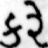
કરે
